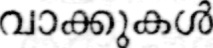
വാക്കുകള്‍
